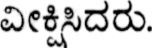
ವೀಕ್ಷಿಸಿದರು.
